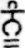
ਨੂੰ
